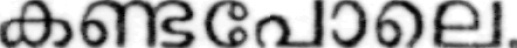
കണ്ടപോലെ.
